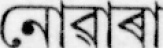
নোৱাৰা
